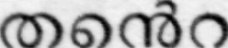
തന്റെ
